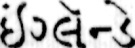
ઇંગ્લૅન્ડે
